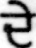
ਦੇ
